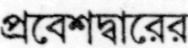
প্রবেশদ্বারের
